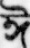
ঈ
